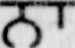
ਨਾ
